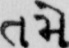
તમે
